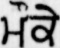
ਮੌਕੇ
